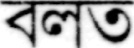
বলত
